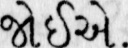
જોઈએ.
